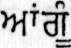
ਆਂਗੂੰ
